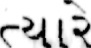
ત્યારે
